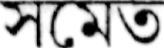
সমেত
